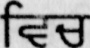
ਵਿਚ
